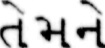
તેમને
